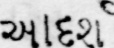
આદર્શ
